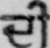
ਦੀ
